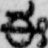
ಈ
